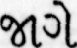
જાગે
